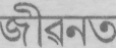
জীৱনত
